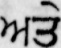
ਅਤੇ
